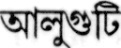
আলুগুটি
